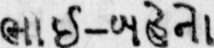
ભાઈ-બહેનો
